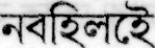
নবহিলই
